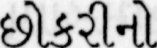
છોકરીનો
